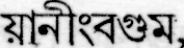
য়ানীংবগুম,
